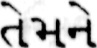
તેમને
